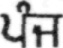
ਪੰਜ
